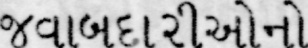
જવાબદારીઓનો
